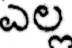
ಎಲ್ಲ
